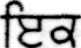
ਇਕ
